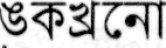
ঙকখ্রনো
